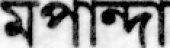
মপান্দা
